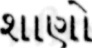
શાણો
